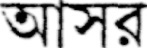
আসর
